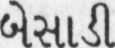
બેસાડી
